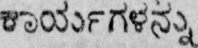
ಕಾರ್ಯಗಳನ್ನು
